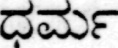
ಧರ್ಮ
